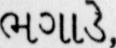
ભગાડે,
